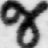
જ
